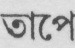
তাপে
